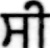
ਸੀ
